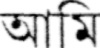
আমি
